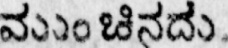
ಮುಂಚಿನದು.
